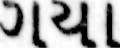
ગયા
